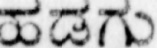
ಹಡಗು
